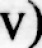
v)
